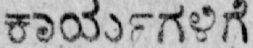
ಕಾರ್ಯಗಳಿಗೆ
